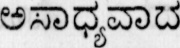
ಅಸಾಧ್ಯವಾದ
